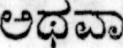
ಅಥವಾ
